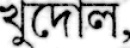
খুদোল,
